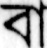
বা
